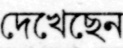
দেখেছেন
